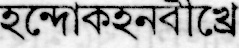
হন্দোকহনবীখ্রে
